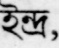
ইন্দ্র,
